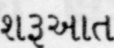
શરૂઆત
